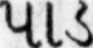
પાડ
